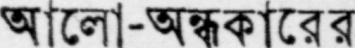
আলো-অন্ধকারের
